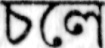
চলে
